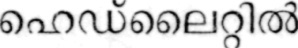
ഹെഡ്ലൈറ്റില്‍
